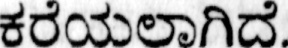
ಕರೆಯಲಾಗಿದೆ.
